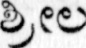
ಶ್ರೀಲ
